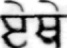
ਏਥੇ
